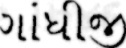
ગાંધીજી
